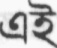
এই
